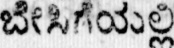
ಬೇಸಿಗೆಯಲ್ಲಿ
